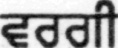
ਵਰਗੀ
